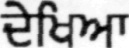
ਦੇਖਿਆ
